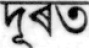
দূৰত
